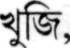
খুজি,
